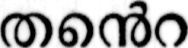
തന്റെ
